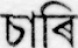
চাৰি
